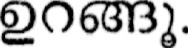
ഉറങ്ങൂ.
